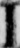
I
